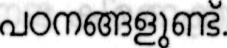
പഠനങ്ങളുണ്ട്.
